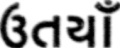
ઉતર્યા
